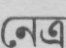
নেত্ৰ
